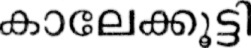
കാലേക്കൂട്ടി
